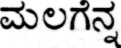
ಮಲಗೆನ್ನ
